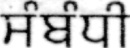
ਸੰਬੰਧੀ
